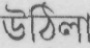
উঠিলা
